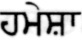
ਹਮੇਸ਼ਾਂ
